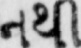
નથી
